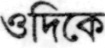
ওদিকে
